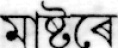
মাষ্টৰে
